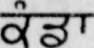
ਕੰਡਾ
